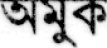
অমুক
